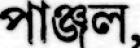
পাঞ্জল,
